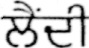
ਲੈਂਦੀ
